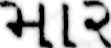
માર
